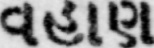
વહાણ
